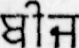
ਬੀਜ
